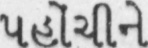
પહોંચીને
